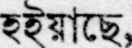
হইয়াছে,
